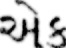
એક
